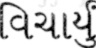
વિચાર્યું
